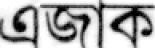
এজাক
